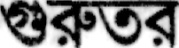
গুরুতর
